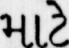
માટે
